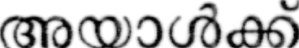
അയാള്‍ക്ക്
